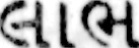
લાભ
